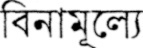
বিনামূল্যে
